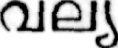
വല്യ
